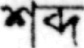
শব্দ
